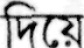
দিয়ে
